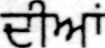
ਦੀਆਂ
